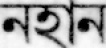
নহান
